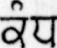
ਕੰਧ
